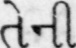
તેની
